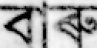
বাৰু
